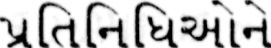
પ્રતિનિધિઓને
